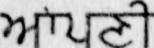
ਆਪਣੀ
